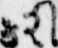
કરી
